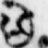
છે.
